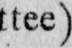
ttee)
